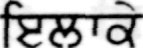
ਇਲਾਕੇ
